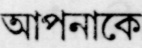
আপনাকে
